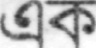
এক
